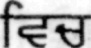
ਵਿਚ
